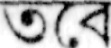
তবে
